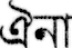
ঐনা
